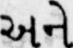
અને
